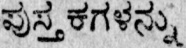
ಪುಸ್ತಕಗಳನ್ನು
